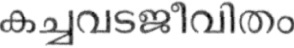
കച്ചവടജീവിതം
